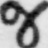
જ
